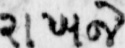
રાખજે
